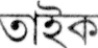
তাইক
